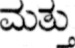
ಮತ್ತು
